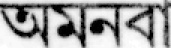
অমনবা
